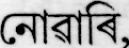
নোৱাৰি,
